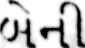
બેની
